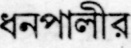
ধনপালীর
